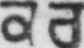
ਕਰ
